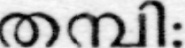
തമ്പി:
